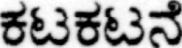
ಕಟಕಟನೆ
